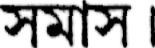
সমাস।
